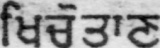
ਖਿਚੋਤਾਣ
